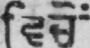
ਵਿਚੋਂ
